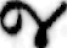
જ
